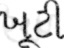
ખૂટી
